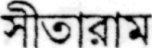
সীতারাম
